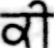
ਕੀ
